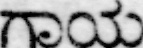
ಗಾಯ
